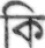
কি
